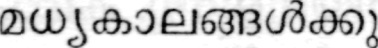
മധ്യകാലങ്ങള്‍ക്കു
